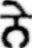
ਨੇ
